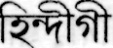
হিন্দীগী
